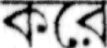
করে
